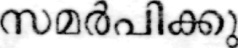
സമര്‍പിക്കു
